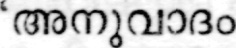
‘അനുവാദം
